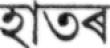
হাতৰ
